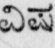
ವಿಷ
